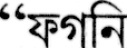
“ফগনি
